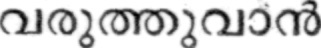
വരുത്തുവാന്‍
